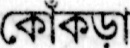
কোঁকড়া
